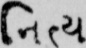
નિત્ય
